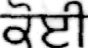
ਕੋਈ
